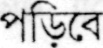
পড়িবে
